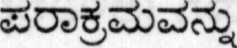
ಪರಾಕ್ರಮವನ್ನು
